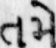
તમે
